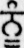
ਨੂੰ
